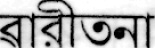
ৱারীতনা
